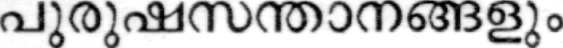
പുരുഷസന്താനങ്ങളും
